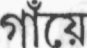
গাঁয়ে
